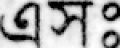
এসঃ
